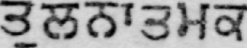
ਤੁਲਨਾਤਮਕ
